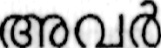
അവര്‍
